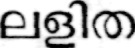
ലളിത
